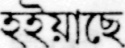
হইয়াছে
